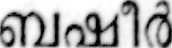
ബഷീര്‍
